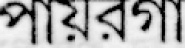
পায়রগা
